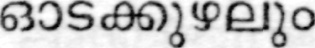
ഓടക്കുഴലും
